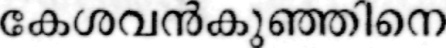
കേശവന്‍കുഞ്ഞിനെ
